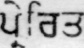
ਪ੍ਰੇਰਿਤ
